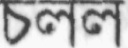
চলল
